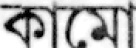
কামো
